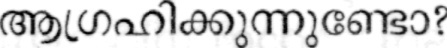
ആഗ്രഹിക്കുന്നുണ്ടോ?
